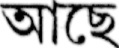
আছে
